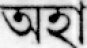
অহা
